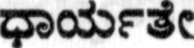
ಧಾರ್ಯತೇ
